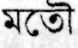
মতৌ
